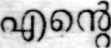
എന്റെ
